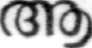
ആ
